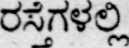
ರಸ್ತೆಗಳಲ್ಲಿ
